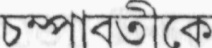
চম্পাবতীকে
